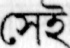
সেই
